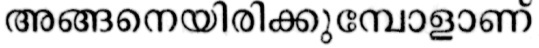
അങ്ങനെയിരിക്കുമ്പോളാണ്
